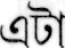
এটা
